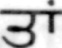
ਤਾਂ
